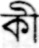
কী
